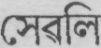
সেৱলি
